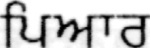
ਪਿਆਰ
